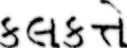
કલકત્તે
